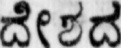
ದೇಶದ
